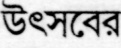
উত্সবের
